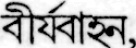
বীর্যবাহন,
